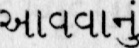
આવવાનું
